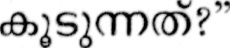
കൂടുന്നത്?"
